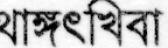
থাঙ্গৎখিবা
